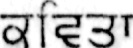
ਕਵਿਤਾ
